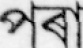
পৰা
